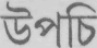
উপচি
